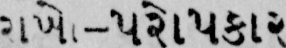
રાખો-પરોપકાર
